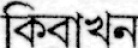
কিবাখন
